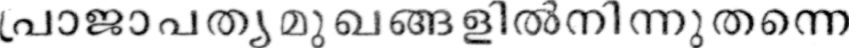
പ്രാജാപത്യമുഖങ്ങളില്‍നിന്നുതന്നെ
